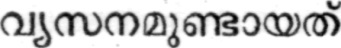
വ്യസനമുണ്ടായത്
